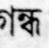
গন্ধ
